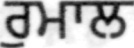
ਰੁਮਾਲ
